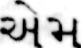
એમ
